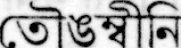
তৌঙম্বীনি
